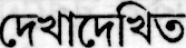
দেখাদেখিত
